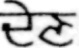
ਦੇਣ
